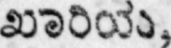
ಖಾರಿಯ,
